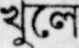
খুলে
